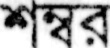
শম্বর
